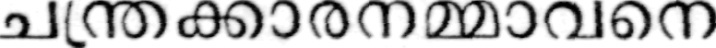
ചന്ത്രക്കാരനമ്മാവനെ
